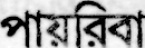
পায়রিবা
